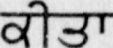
ਕੀਤਾ
